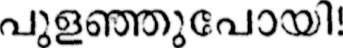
പുളഞ്ഞുപോയി!
